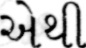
એથી
